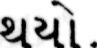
થયો.
